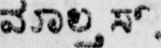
ಮಾಲ್ತಸ್.
